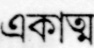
একাত্ম
